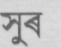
সুৰ
